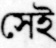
সেই
